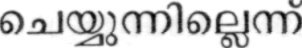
ചെയ്യുന്നില്ലെന്ന്
